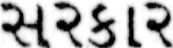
સરકાર
